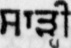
ਸਾੜ੍ਹੀ
